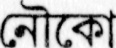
নৌকো
